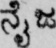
ನೈಜ
